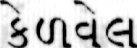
કેળવેલ
